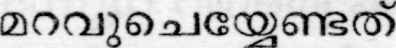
മറവുചെയ്യേണ്ടത്
